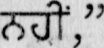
ਨਹੀਂ,''
